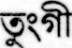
তুংগী
